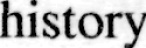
history
